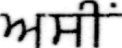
ਅਸੀਂ
